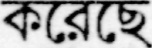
করেছে
